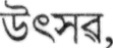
উৎসৱ,
